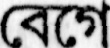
বেগে
